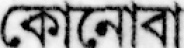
কোনোবা
